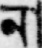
না
